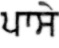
ਪਾਸੇ
